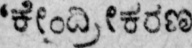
‘ಕೇಂದ್ರೀಕರಣ
